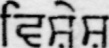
ਵਿਸ਼ੇਸ਼
